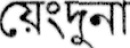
য়েংদুনা
